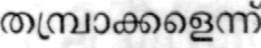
തമ്പ്രാക്കളെന്ന്
